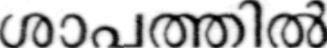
ശാപത്തില്‍
